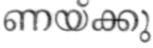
ണയ്ക്കു
